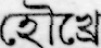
হৌখ্রে
